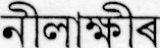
নীলাক্ষীৰ
